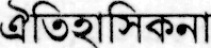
ঐতিহাসিকনা
